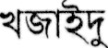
খজাইদু
